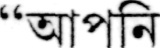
“আপনি
